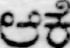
ಆಕೆ
